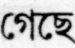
গেছে
